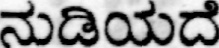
ನುಡಿಯದೆ
